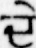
ਦੇ
